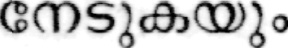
നേടുകയും
